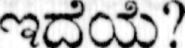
ಇದೆಯೆ?
